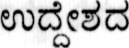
ಉದ್ದೇಶದ
